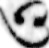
ও
